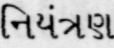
નિયંત્રણ
